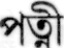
পত্নী
